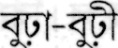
বুঢ়া-বুঢ়ী
